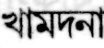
খামদনা
